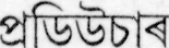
প্রডিউচাৰ
